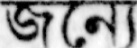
জন্যে
